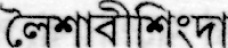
লৈশাবীশিংদা
